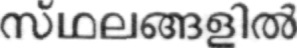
സ്ഥലങ്ങളില്‍
